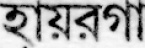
হায়রগা
